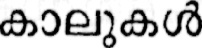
കാലുകള്‍
